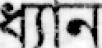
ধ্যান
